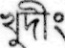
খুদীং
